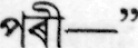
পৰী-"
